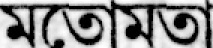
মতোমতা
